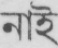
নাই
